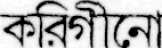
করিগীনো
